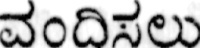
ವಂದಿಸಲು
